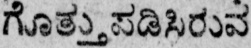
ಗೊತ್ತುಪಡಿಸಿರುವ
